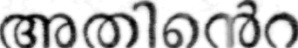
അതിന്റെ
